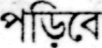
পড়িবে
